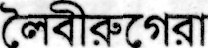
লৈবীরুগেরা
